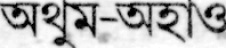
অথুম-অহাও
